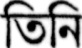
তিনি
